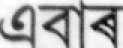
এবাৰ
